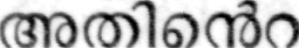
അതിന്റെ
